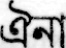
ঐনা
